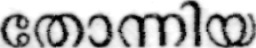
തോന്നിയ
